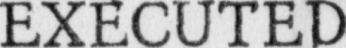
EXECUTED
